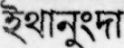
ইথানুংদা
